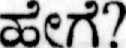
ಹೇಗೆ?
